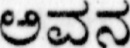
ಅವನ
